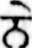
ਨੇ
